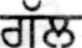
ਗੱਲ
